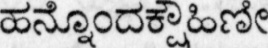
ಹನ್ನೊಂದಕ್ಷಾಹಿಣೀ
